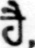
ਹੈ,
